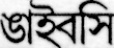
ঙাইবসি
